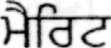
ਮੈਰਿਟ
